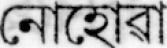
নোহোৱা
